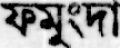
ফমুংদা
